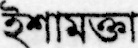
ইশামক্তা
